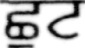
ਛੁਟ
